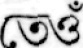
তেওঁ
